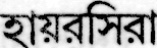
হায়রসিরা
